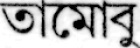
তামোবু
